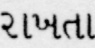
રાખતા
